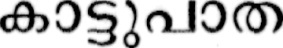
കാട്ടുപാത
